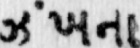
ઝંખના
